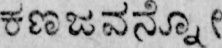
ಕಣಜವನ್ನೋ
